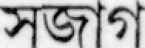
সজাগ
